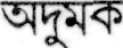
অদুমক
